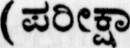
(ಪರೀಕ್ಷಾ
